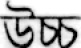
উচ্চ
